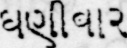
ઘણીવાર
